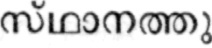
സ്ഥാനത്തു
